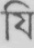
যি
